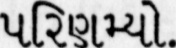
પરિણમ્યો.
